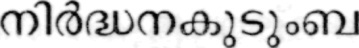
നിര്‍ദ്ധനകുടുംബ
